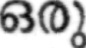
ഒരു
